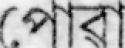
পোৱা
